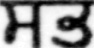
ਸਭ
